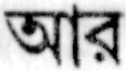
আর
